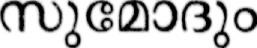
സുമോദും
